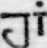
ਹਾਂ
